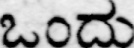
ಒಂದು
